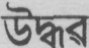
উদ্ধৱ
